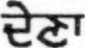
ਦੇਣਾ
